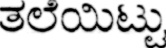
ತಲೆಯಿಟ್ಟು
